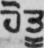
ਹੋਤੂ
